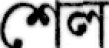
শেল
